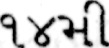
૧૪મી
